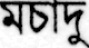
মচাদু
